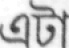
এটা
